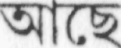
আছে
